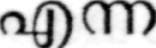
എന്ന
